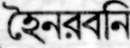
হৈনরবনি
